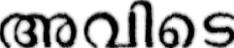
അവിടെ
